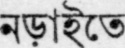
নড়াইতে
